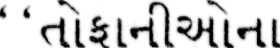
"તોફાનીઓના
